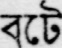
বটে
